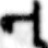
ન
